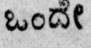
ಒಂದೇ
